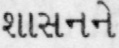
શાસનને
